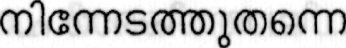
നിന്നേടത്തുതന്നെ
